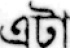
এটা
